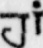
ਹਾਂ
